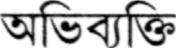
অভিব্যক্তি
